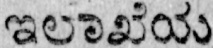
ಇಲಾಖೆಯ
